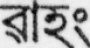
ৱাহং
